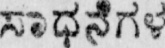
ಸಾಧನೆಗಳ
